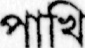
পাখি
